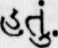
હતું.
